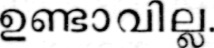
ഉണ്ടാവില്ല.
